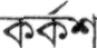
কর্কশ
